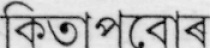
কিতাপবোৰ
